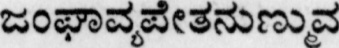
ಜಂಘಾವ್ಯಪೇತನುಣ್ಮುವ
